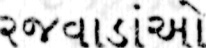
રજવાડાંઓ
